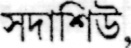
সদাশিউ,
